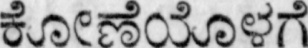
ಕೋಣೆಯೊಳಗೆ
